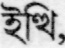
ইত্থি,
